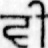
ਵੀ
